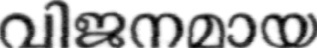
വിജനമായ
